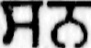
ਸਨ
